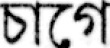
চাগে
